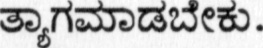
ತ್ಯಾಗಮಾಡಬೇಕು.
